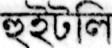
হুইটলি
